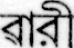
ৱারী
